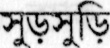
সুড়সুড়ি
